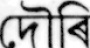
দৌৰি
